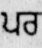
ਪਰ
